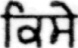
ਕਿਸੇ
